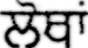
ਲੋਥਾਂ
